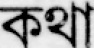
কথা
